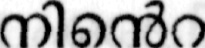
നിന്റെ
